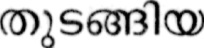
തുടങ്ങിയ
